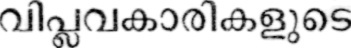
വിപ്ലവകാരികളുടെ
